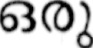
ഒരു
